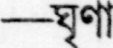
–ঘৃণা
